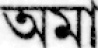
অমা
